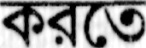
করতে
